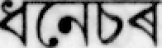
ধনেচৰ
